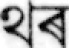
থৰ
